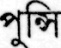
পুন্সি
